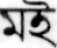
মই
